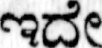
ಇದೇ
